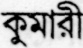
কুমারী
